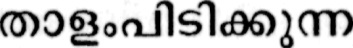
താളംപിടിക്കുന്ന
